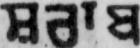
ਸ਼ਰਾਬ
